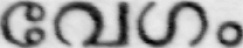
വേഗം
